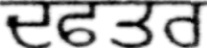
ਦਫਤਰ
